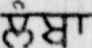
ਲੰਬਾ
